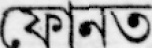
ফোনত
